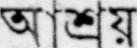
আশ্রয়
